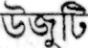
উজুটি
